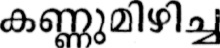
കണ്ണുമിഴിച്ച
